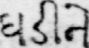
ઘડીને
